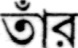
তাঁর
